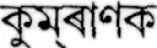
কুম্‌ৰাণক
